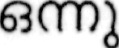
ഒന്നു
